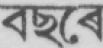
বছৰে
